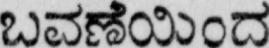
ಬವಣೆಯಿಂದ
